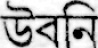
উবনি
